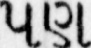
પણ
